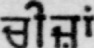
ਚੀਜ਼ਾਂ
